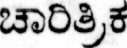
ಚಾರಿತ್ರಿಕ
